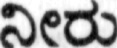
ನೀರು
